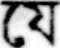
যে
